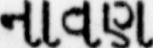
નાવણ
